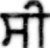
ਸੀ
